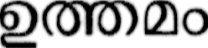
ഉത്തമം
